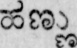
ಹಣ್ಣು
